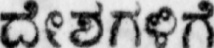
ದೇಶಗಳಿಗೆ
